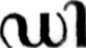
ഡി
